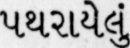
પથરાયેલું
